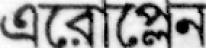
এরোপ্লেন
